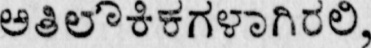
ಅತಿಲೌಕಿಕಗಳಾಗಿರಲಿ,
